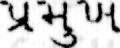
પ્રમુખ
